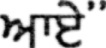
ਆਏ''
